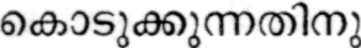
കൊടുക്കുന്നതിനു
